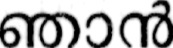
ഞാന്‍
